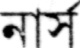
নার্স
